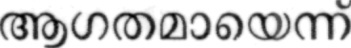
ആഗതമായെന്ന്
